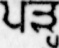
ਪੜ੍ਹ
